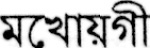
মখোয়গী
